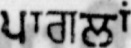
ਪਾਗਲਾਂ
